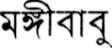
মঙ্গীবাবু
